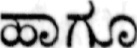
ಹಾಗೂ
